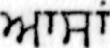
ਆਸਾਂ
